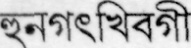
হুনগৎখিবগী
